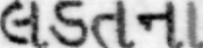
લડતના
